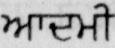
ਆਦਮੀ
